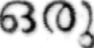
ഒരു
